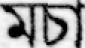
মচা
